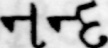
નન્દ
